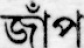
জাঁপ
